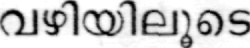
വഴിയിലൂടെ
